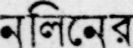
নলিনের
